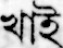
খাই
